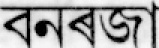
বনৰজা
